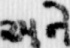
અને
